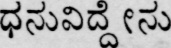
ಧನುವಿದ್ದೇನು
